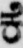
ಕೆ
